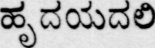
ಹೃದಯದಲಿ
